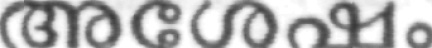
അശേഷം
